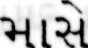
માસે
